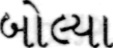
બોલ્યા
